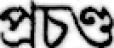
প্রচণ্ড
